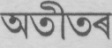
অতীতৰ
